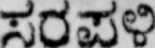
ಸರಪಳಿ
